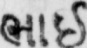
ભાઈ
